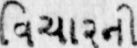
વિચારની
